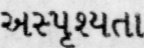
અસ્પૃશ્યતા
